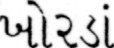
ખોરડાં
